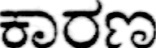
ಕಾರಣ
